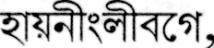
হায়নীংলীবগে,
